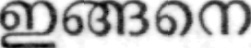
ഇങ്ങനെ
